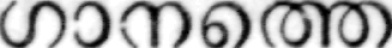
ഗാനത്തെ
